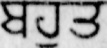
ਬਹੁਤ
